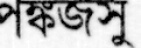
পঙ্কজসু
